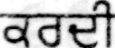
ਕਰਦੀ
